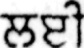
ਲਈ
